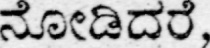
ನೋಡಿದರೆ,
